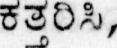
ಕತ್ತರಿಸಿ,
